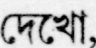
দেখো,
